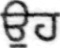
ਉਹ
